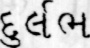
દુર્લભ
